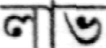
লাভ
